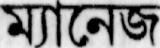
ম্যানেজ
